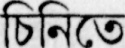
চিনিতে
